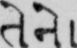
તેનો
